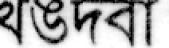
খঙদবা
